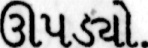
ઊપડ્યો.
